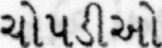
ચોપડીઓ
